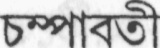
চম্পাবতী
